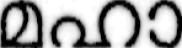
മഹാ
